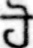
ਹੋ
